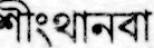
শীংথানবা
